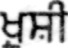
ਖੁਸ਼ੀ
